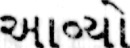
આવ્યો
